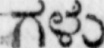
ಗಳು
